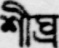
শীঘ্র
